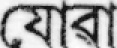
যোৱা
